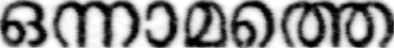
ഒന്നാമത്തെ
